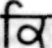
ਕਿ
